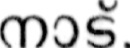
നാട്.
